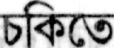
চকিতে
